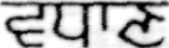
ਵਧਾਣ
